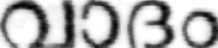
വാദം
